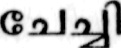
ചേച്ചി
